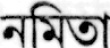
নমিতা
